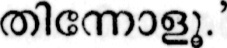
തിന്നോളൂ.'
